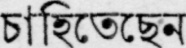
চাহিতেছেন
